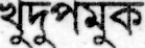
খুদুপমুক
